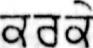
ਕਰਕੇ
